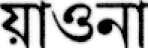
য়াওনা
